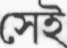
সেই
